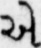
એ
